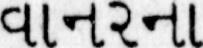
વાનરના
